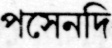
পসেনদি
